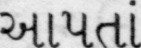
આપતાં
